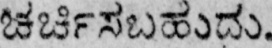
ಚರ್ಚಿಸಬಹುದು.
